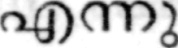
എന്നു
